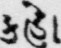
કહો
